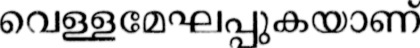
വെള്ളമേഘപ്പുകയാണ്
